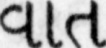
વાત
